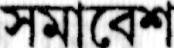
সমাবেশ
